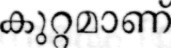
കുറ്റമാണ്
